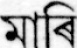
মাৰি
